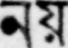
নয়
